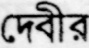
দেবীর
